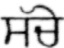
ਸੱਚੇ
